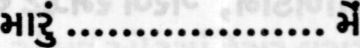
મારું............મેં
